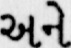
અને
